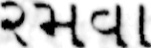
રમવા
